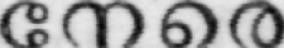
നേരെ
